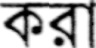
করা
